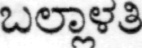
ಬಲ್ಲಾಳತಿ
